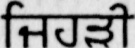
ਜਿਹੜੀ
